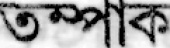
তম্পাক
